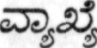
ವ್ಯಾಖ್ಯೆ
